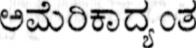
ಅಮೆರಿಕಾದ್ಯಂತ
